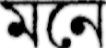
মনে
